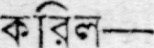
করিল—
